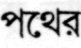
পথের
